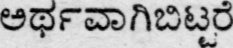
ಅರ್ಥವಾಗಿಬಿಟ್ಟರೆ
